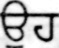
ਉਹ
